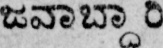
ಜವಾಬ್ದಾರಿ
